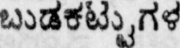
ಬುಡಕಟ್ಟುಗಳ
